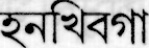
হনখিবগা
